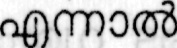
എന്നാല്‍
